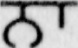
ਨਾ
